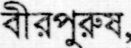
বীরপুরুষ,
